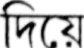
দিয়ে
